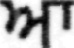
ਆ
